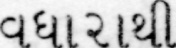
વધારાથી
